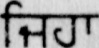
ਜਿਹਾ
